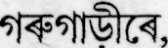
গৰুগাড়ীৰে,
